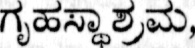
ಗೃಹಸ್ಥಾಶ್ರಮ,
